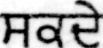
ਸਕਦੇ
